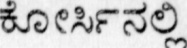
ಕೋರ್ಸಿನಲ್ಲಿ
